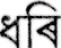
ধৰি
